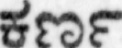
ಕರ್ಣ
